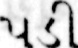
પડી
